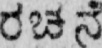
ರಚನೆ
